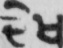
ਦੇਖ
